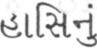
હાસિનું
